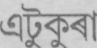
এটুকুৰা
